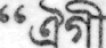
“ঐগী
